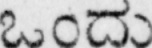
ಒಂದು
